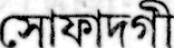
সোফাদগী
